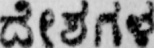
ದೇಶಗಳ
